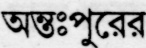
অন্তঃপুরের
